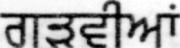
ਗੜਵੀਆਂ
